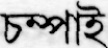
চম্পাই
